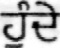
ਹੁੰਦੇ
